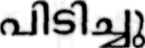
പിടിച്ചു
